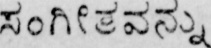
ಸಂಗೀತವನ್ನು
